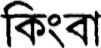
কিংবা
